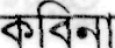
কবিনা
